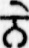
ਨੇ
